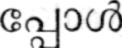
പ്പോള്‍
